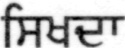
ਸਿਖਦਾ
